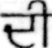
ਦੀ
